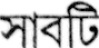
সাবটি
